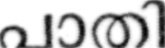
പാതി
